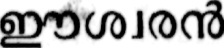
ഈശ്വരന്‍
